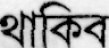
থাকিব
